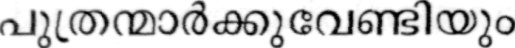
പുത്രന്മാര്‍ക്കുവേണ്ടിയും
